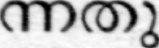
ന്നതു
